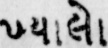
ખ્યાલો
